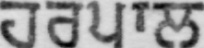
ਹਰਪਾਲ
